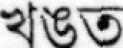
খঙত
